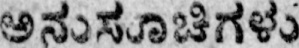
ಅನುಸೂಚಿಗಳ
